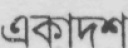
একাদশ
